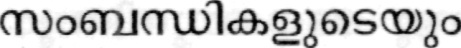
സംബന്ധികളുടെയും
